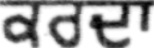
ਕਰਦਾ
